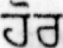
ਹੋਰ
